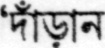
‘দাঁড়ান
